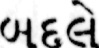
બદલે
